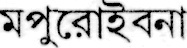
মপুরোইবনা
